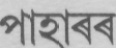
পাহাৰৰ
